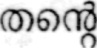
തന്റെ
